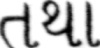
તથા
